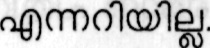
എന്നറിയില്ല.
